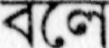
বলে
